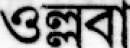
ওল্লগা
